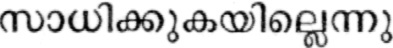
സാധിക്കുകയില്ലെന്നു
